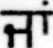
ਜਾਂ
